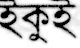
ইকুই
